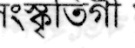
সংস্কৃতিগী
